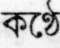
কণ্ঠে
